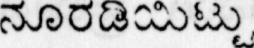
ನೂರಡಿಯಿಟ್ಟು
